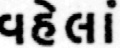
વહેલાં
